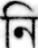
নি
